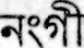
নংগী
